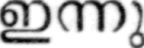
ഇന്നു
